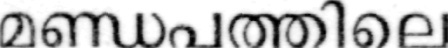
മണ്ഡപത്തിലെ
